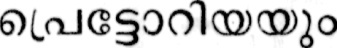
പ്രെട്ടോറിയയും
